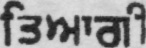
ਤਿਆਗੀ
